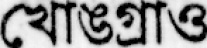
খোঙগ্রাও
